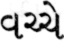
વચ્ચે
